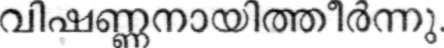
വിഷണ്ണനായിത്തീര്‍ന്നു.
